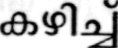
കഴിച്ച്
